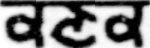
ਕਣਕ
